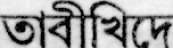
তাবীখিদে
